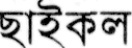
ছাইকল
